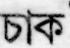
চাক
